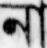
না
